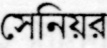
সেনিয়র
